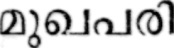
മുഖപരി
